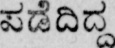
ಪಡೆದಿದ್ದ
